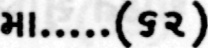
મા.....(૬૨)
